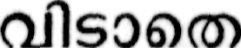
വിടാതെ
